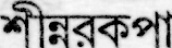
শীন্নরকপা
